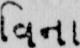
વિના
